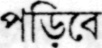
পড়িবে
